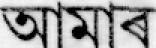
আমাৰ
